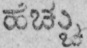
ಹೆಚ್ಚು
